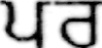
ਪਰ
